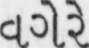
વગેરે
